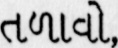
તળાવો,
